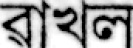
ৱাখল
